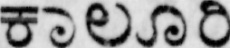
ಕಾಲೂರಿ
